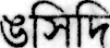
ঙসিদি
